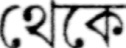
থেকে
